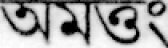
অমত্তং
